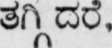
ತಗ್ಗಿದರೆ,
